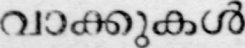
വാക്കുകള്‍
